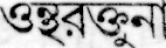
ওন্থরক্তুনা
